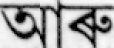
আৰু
